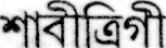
শাবীত্রিগী
